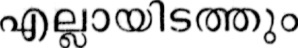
എല്ലായിടത്തും
